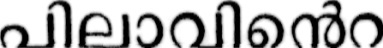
പിലാവിന്റെ
